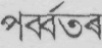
পৰ্ব্বতৰ
